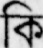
কি
